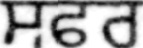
ਸਫਰ
